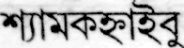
শ্যামকহ্ণাইবু
